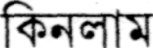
কিনলাম
